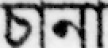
চানা
